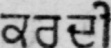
ਕਰਦੀ
